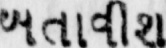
બતાવીશ
